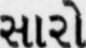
સારો
